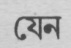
যেন
